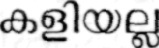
കളിയല്ല
